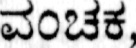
ವಂಚಕ,
